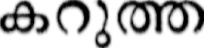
കറുത്ത
